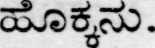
ಹೊಕ್ಕನು.
